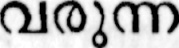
വരുന്ന
